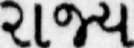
રાજ્ય
